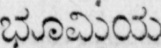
ಭೂಮಿಯ
